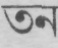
তন
